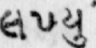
લખ્યું
